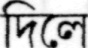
দিলে
